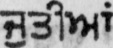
ਜੁਤੀਆਂ
